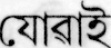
যোৱাই
